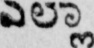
ಎಲ್ಲಾ
